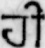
ਹੀ
